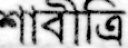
শাবীত্রি
